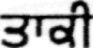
ਤਾਕੀ
